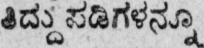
ತಿದ್ದುಪಡಿಗಳನ್ನೂ
